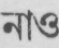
নাও
